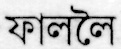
ফাললৈ
